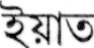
ইয়াত
